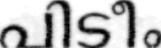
പിടീം
